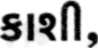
કાશી,
